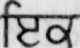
ਇਕ
